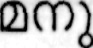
മനു
